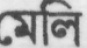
মেলি
